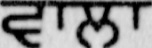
ਵਾਲਾ
